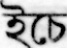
ইচে
